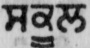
ਸਕੂਲ
